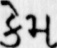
કેમ
